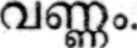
വണ്ണം.
